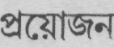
প্ৰয়োজন
